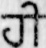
ਹੀ
